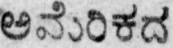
ಅಮೆರಿಕದ
